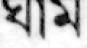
ঘাম
